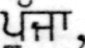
ਪੁੱਜਾ,
